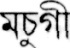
মচুগী
